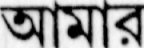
আমার
